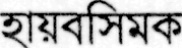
হায়বসিমক
